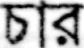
চার
